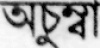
অচুম্বা
